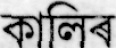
কালিৰ
